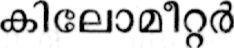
കിലോമീറ്റര്‍
